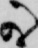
જે
